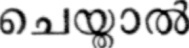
ചെയ്താല്‍
